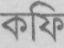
কফি
